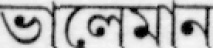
ভালেমান
